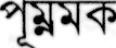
পূম্নমক
